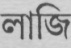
লাজি
